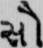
સૌ
